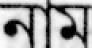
নাম
